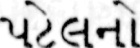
પટેલનો
